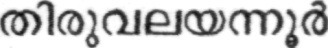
തിരുവലയന്നൂര്‍
